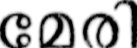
മേരി
